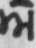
ਅ
